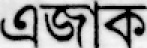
এজাক
